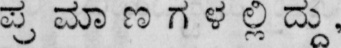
ಪ್ರಮಾಣಗಳಲ್ಲಿದ್ದು,
